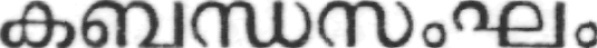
കബന്ധസംഘം
